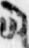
બે
